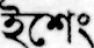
ইশেং
